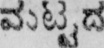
ಮಟ್ಟದ
